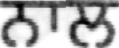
ਨਾਲ
